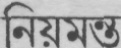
নিয়মন্ত
